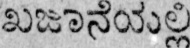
ಖಜಾನೆಯಲ್ಲಿ
